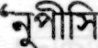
‘নুপীসি
